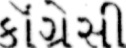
કૉંગ્રેસી
